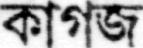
কাগজ
